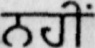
ਨਹੀਂ
